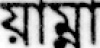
য়াম্না
